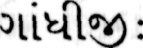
ગાંધીજીઃ
